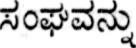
ಸಂಘವನ್ನು
